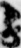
કે
